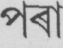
পৰা
